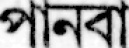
পানবা
